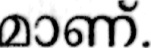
മാണ്.
